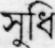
সুধি
